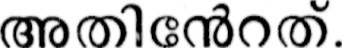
അതിന്റേത്.
